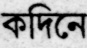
কদিনে
